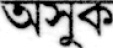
অসুক
